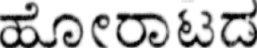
ಹೋರಾಟದ
